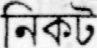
নিকট
